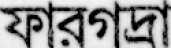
ফারগদ্রা
